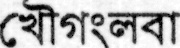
খৌগংলবা
